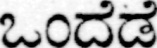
ಒಂದೆಡೆ
